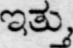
ಇತ್ತು,
